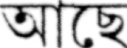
আছে
